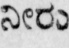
ನೀರು
